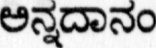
ಅನ್ನದಾನಂ
